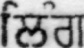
ਲਿੰਗ
